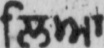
ਲਿਆ
